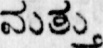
ಮತ್ತು
